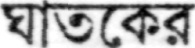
ঘাতকের
